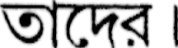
তাদের।
